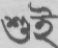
শুই
